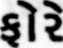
ફોરે
